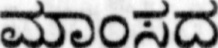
ಮಾಂಸದ
